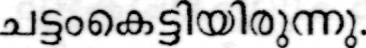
ചട്ടംകെട്ടിയിരുന്നു.
